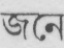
জনে
